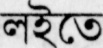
লইতে
